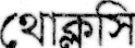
থোক্লসি
